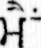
ਮੈਂ
